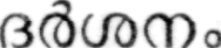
ദര്‍ശനം
